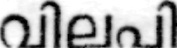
വിലപി
